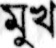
মুখ
